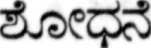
ಶೋಧನೆ
